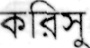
করিসু
